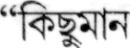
"কিছুমান
